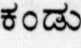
ಕಂಡು
